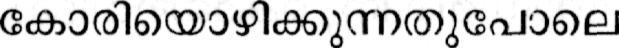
കോരിയൊഴിക്കുന്നതുപോലെ
